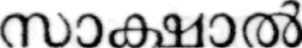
സാക്ഷാല്‍
